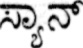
ಸ್ಯಾನ್
